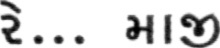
રે.....માજી
